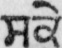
ਸਕੇ
